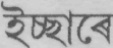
ইচ্ছাৰে
